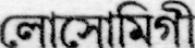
লোসোমিগী
